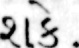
શકે.
